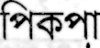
পিকপা
